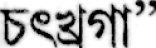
চৎখ্রগা”
